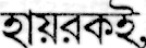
হায়রকই,
